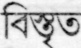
বিস্তৃত
